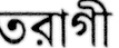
তরাগী
